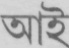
আই
